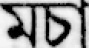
মচা
